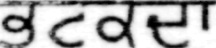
ਭਟਕਦਾ
